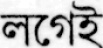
লগেই
